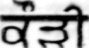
ਕੌੜੀ
